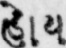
હોય
